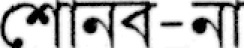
শোনব-না
